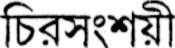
চিরসংশয়ী
